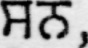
ਸਨ,
